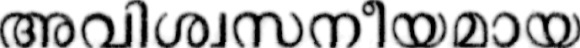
അവിശ്വസനീയമായ
